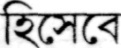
হিসেবে
